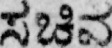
ಸಚಿವ
